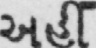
અહીં
